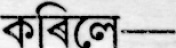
কৰিলে-
